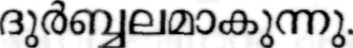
ദുര്‍ബ്ബലമാകുന്നു.
